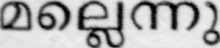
മല്ലെന്നു
